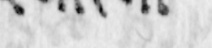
પરમાત્મા
